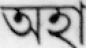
অহা
